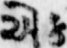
એક
